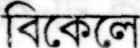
বিকেলে
